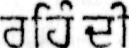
ਰਹਿੰਦੀ
